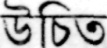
উচিত
